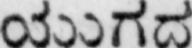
ಯುಗದ
